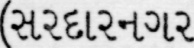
(સરદારનગર
